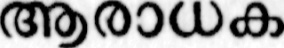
ആരാധക
